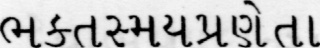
ભક્તસ્મયપ્રણેતા
